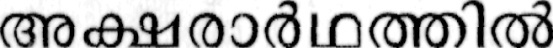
അക്ഷരാര്‍ഥത്തില്‍
